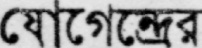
যোগেন্দ্রের
